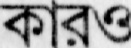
কারও
